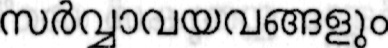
സര്‍വ്വാവയവങ്ങളും
